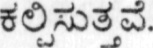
ಕಲ್ಪಿಸುತ್ತವೆ.
